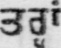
ਤਰ੍ਹਾਂ
